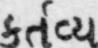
કર્તવ્ય
